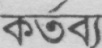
কর্তব্য
